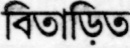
বিতাড়িত
